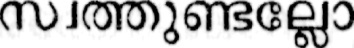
സ്വത്തുണ്ടല്ലോ
